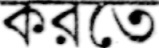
করতে
